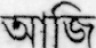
আজি
